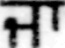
ਜਾ
